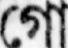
গো
